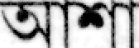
আশা
